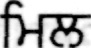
ਮਿਲ
